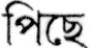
পিছে
